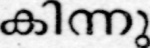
കിന്നു
